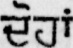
ਦੋਹਾਂ
